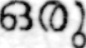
ഒരു
